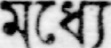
মধ্যে
